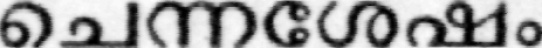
ചെന്നശേഷം
